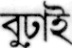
বুঢাই
